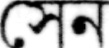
সেন
